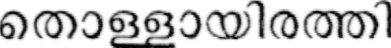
തൊള്ളായിരത്തി
